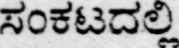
ಸಂಕಟದಲ್ಲಿ
